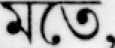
মতে,
